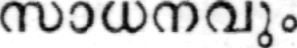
സാധനവും
